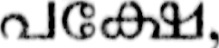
പക്ഷേ,
